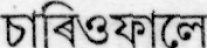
চাৰিওফালে
